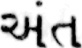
અંત
